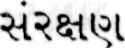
સંરક્ષણ
